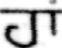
ਹਾਂ
